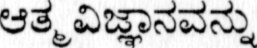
ಆತ್ಮವಿಜ್ಞಾನವನ್ನು
